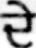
ਦੇ
